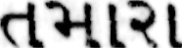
તમારા
